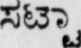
ಸಟ್ಟಾ
